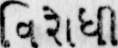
વિરોધી
